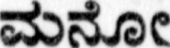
ಮನೋ
